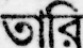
তারি
